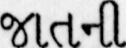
જાતની
